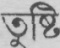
তুষ্টি
